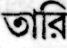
তারি
